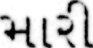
મારી
